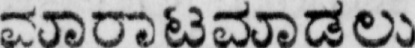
ಮಾರಾಟಮಾಡಲು
